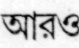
আরও
